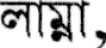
লাম্না,
